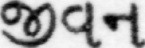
જીવન
